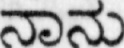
ನಾನು
